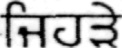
ਜਿਹੜੇ
